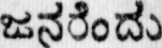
ಜನರೆಂದು
